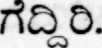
ಗೆದ್ದಿರಿ.
